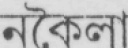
নকৈলা
